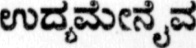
ಉದ್ಯಮೇನೈವ
